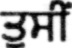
ਤੁਸੀਂ
